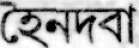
হৈনদবা
